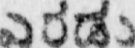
ಎರಡು
